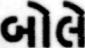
બોલે
